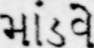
માંડવે
